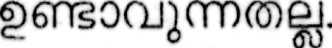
ഉണ്ടാവുന്നതല്ല.
